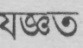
যজ্ঞত
